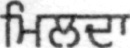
ਮਿਲਦਾ
